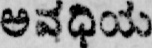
ಅವಧಿಯ
